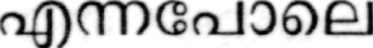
എന്നപോലെ
